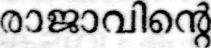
രാജാവിന്റെ
